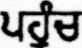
ਪਹੁੰਚ
